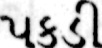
પકડી
